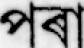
পৰা
